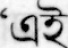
'এই
